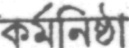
কর্মনিষ্ঠা
